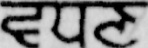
ਵਧਣ
